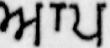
ਆਪ
